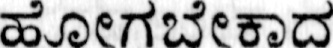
ಹೋಗಬೇಕಾದ
